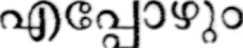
എപ്പോഴും
